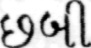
છબી
